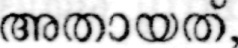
അതായത്,
